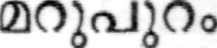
മറുപുറം
